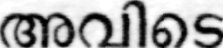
അവിടെ
